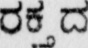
ರಕ್ತದ
